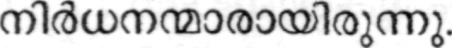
നിര്‍ധനന്മാരായിരുന്നു.
